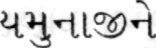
યમુનાજીને
